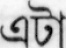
এটা
